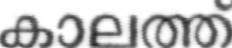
കാലത്ത്
